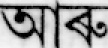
আৰু
